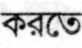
করতে
